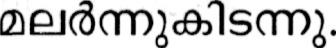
മലര്‍ന്നുകിടന്നു.
